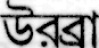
উরব্রা
